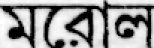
মরোল
